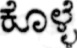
ಕೊಳ್ಳೆ
